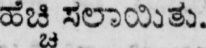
ಹೆಚ್ಚಿಸಲಾಯಿತು.
